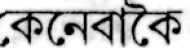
কেনেবাকৈ
